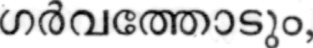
ഗര്‍വത്തോടും,
